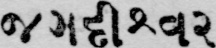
જગદીશ્વર
